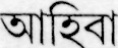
আহিবা
